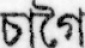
চাগৈ
